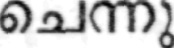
ചെന്നു
